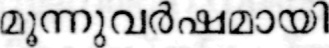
മൂന്നുവര്‍ഷമായി
